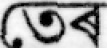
তেৰ
